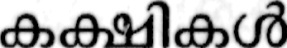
കക്ഷികള്‍
